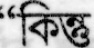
"কিন্তু
